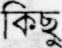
কিছু
